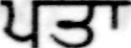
ਪਤਾ
